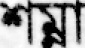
শম্না
